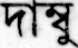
দাম্বু
